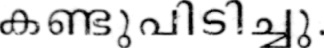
കണ്ടുപിടിച്ചു.
